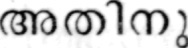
അതിനു
